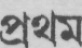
প্ৰথম
